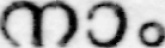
നാം
